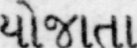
યોજાતા
